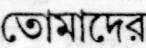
তোমাদের
